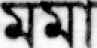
মমা
